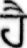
ਹੈ
